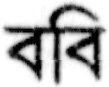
ববি
